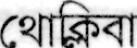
থোক্লিবা
